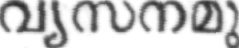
വ്യസനമു
